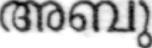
അബു
